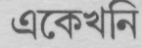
একেখনি
